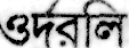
ওর্দরলি
